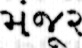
મંજૂર
